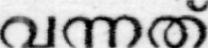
വന്നത്
